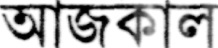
আজকাল
